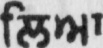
ਲਿਆ
